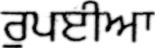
ਰੁਪਈਆ
